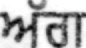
ਅੱਗ
